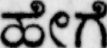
ಹೇಗೆ
